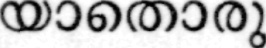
യാതൊരു
